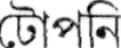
টোপনি
